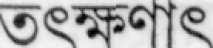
তৎক্ষণাৎ
